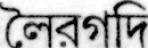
লৈরগদি
